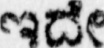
ಇದೇ
